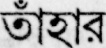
তাঁহার
